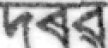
দৰৱ
